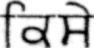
ਕਿਸੇ
